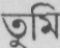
তুমি
